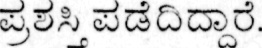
ಪ್ರಶಸ್ತಿಪಡೆದಿದ್ದಾರೆ.
